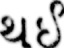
થઈ
